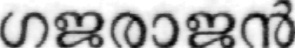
ഗജരാജന്‍
